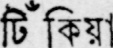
টিঁকিয়া
